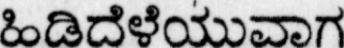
ಹಿಡಿದೆಳೆಯುವಾಗ
